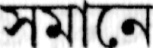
সমানে
